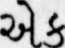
એક
